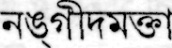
নঙগীদমক্তা
